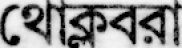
থোক্লবরা
